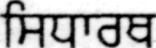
ਸਿਧਾਰਥ
